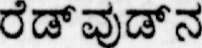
ರೆಡ್‌ವುಡ್ ನ
